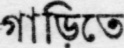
গাড়িতে
